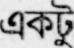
একটু
